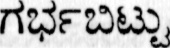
ಗರ್ಭಬಿಟ್ಟು
